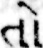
તો
